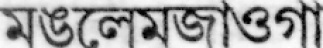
মঙলেমজাওগা
